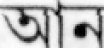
আন
